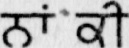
ਨਾਂਕੀ
